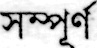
সম্পূর্ণ
